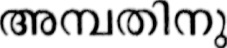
അമ്പതിനു
